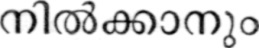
നില്‍ക്കാനും
